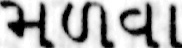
મળવા
